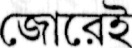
জোরেই
